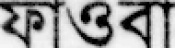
ফাওবা
